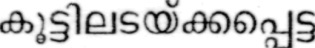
കൂട്ടിലടയ്ക്കപ്പെട്ട
